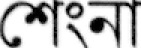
শেংনা
